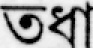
তধা
